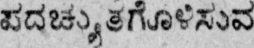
ಪದಚ್ಯುತಗೊಳಿಸುವ
